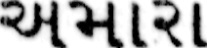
અમારા
